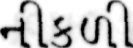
નીકળી
